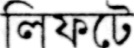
লিফটে
